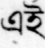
এই
